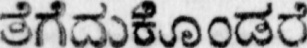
ತೆಗೆದುಕೊಂಡರೆ
